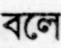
বলে
